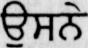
ਉਸਨੇ
